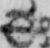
ಈ
